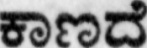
ಕಾಣದೆ
